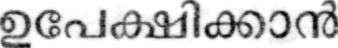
ഉപേക്ഷിക്കാന്‍
